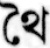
থৈ
